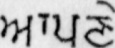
ਆਪਣੇ
